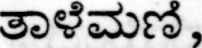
ತಾಳೆಮಣಿ,
